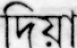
দিয়া
